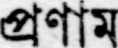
প্রণাম
